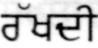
ਰੱਖਦੀ
